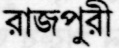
রাজপুরী
